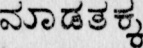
ಮಾಡತಕ್ಕ
